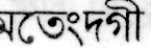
মতেংদগী
